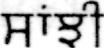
ਸਾਂਝੀ
